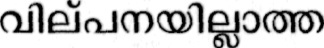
വില്പനയില്ലാത്ത
